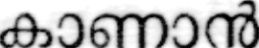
കാണാന്‍
